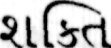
શક્તિ
